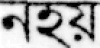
নহয়
